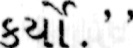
કર્યો."
